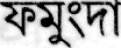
ফমুংদা
